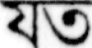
যত
